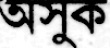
অসুক
